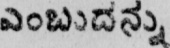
ಎಂಬುದನ್ನು
